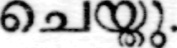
ചെയ്തു.
